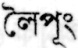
লৈপূং
